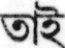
তাই
